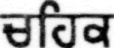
ਚਹਿਕ
